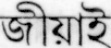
জীয়াই
